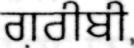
਼ਗਰੀਬੀ,
